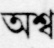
অশ্ব
